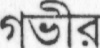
গভীর
